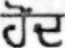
ਹੋਂਦ
